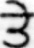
ਤੇ
